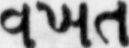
વખત
